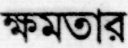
ক্ষমতার
